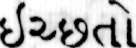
ઈચ્છતો
